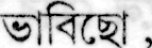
ভাবিছো,
